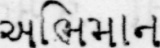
અભિમાન
